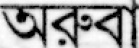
অরুবা
